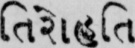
તિરોહતિ
